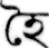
হৈ
